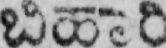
ಬಿಹಾರಿ
